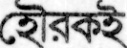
হৌরকই
